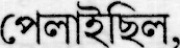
পেলাইছিল,
